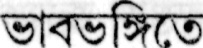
ভাবভঙ্গিতে
